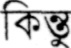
কিন্তু
